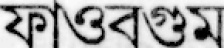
ফাওবগুম
